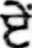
ਏਂ
